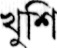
খুশি
